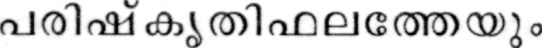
പരിഷ്കൃതിഫലത്തേയും
